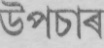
উপচাৰ
